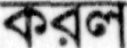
করল
